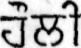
ਹੌਲੀ
